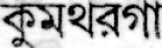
কুমথরগা
